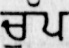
ਚੁੱਪ
